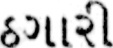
ઠગારી
